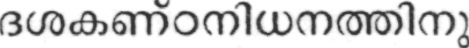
ദശകണ്ഠനിധനത്തിനു
